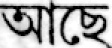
আছে
